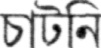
চাটনি
